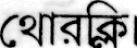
থোরক্লি।
